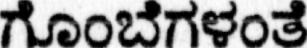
ಗೊಂಬೆಗಳಂತೆ
